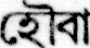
হৌবা
